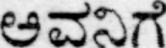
ಅವನಿಗೆ
